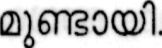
മുണ്ടായി.
